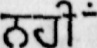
ਨਹੀਂ
